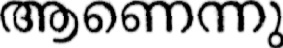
ആണെന്നു
